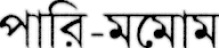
পারি-মমোম
